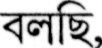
বলছি,
